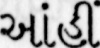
આંહીં
